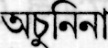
অচুনিনা
